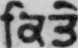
ਕਿਤੇ
